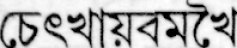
চেৎখায়বমখৈ
